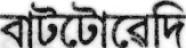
বাটটোৱেদি
